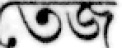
তেজ
